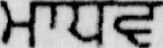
ਮਾਧਵ
